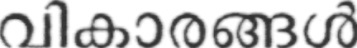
വികാരങ്ങള്‍
